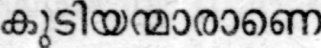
കുടിയന്മാരാണെ
